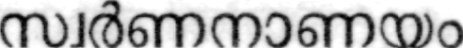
സ്വര്‍ണനാണയം
